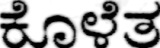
ಕೊಳೆತ
